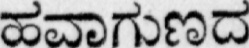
ಹವಾಗುಣದ
